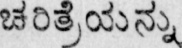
ಚರಿತ್ರೆಯನ್ನು
